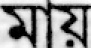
মায়
